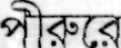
পীরুরে
